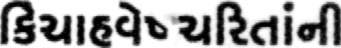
કિંચાહવેષ્ચરિતાંની
